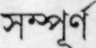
সম্পূর্ণ
